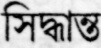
সিদ্ধান্ত
